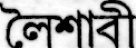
লৈশাবী
